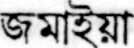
জমাইয়া
